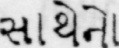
સાથેનો
